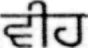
ਵੀਹ
